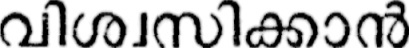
വിശ്വസിക്കാന്‍
